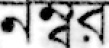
নম্বর
